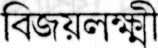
বিজয়লক্ষ্মী
